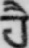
ਹੈ
